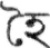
হৈ
